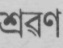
শ্ৰৱণ
